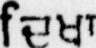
ਦਿਖਾ
